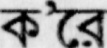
ক'রে
